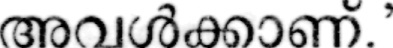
അവള്‍ക്കാണ്.’
